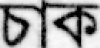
চাক
